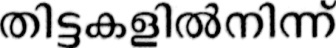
തിട്ടകളില്‍നിന്ന്
